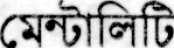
মেল্টালিটি
